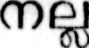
നല്ല
